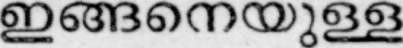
ഇങ്ങനെയുള്ള
